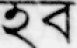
হব
